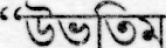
"উভতিম
